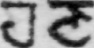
ਹਣ
